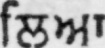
ਲਿਆ
